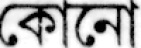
কোনো
